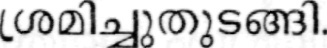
ശ്രമിച്ചുതുടങ്ങി.
